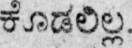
ಕೊಡಲಿಲ್ಲ.
